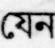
যেন
